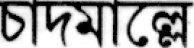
চাদমাল্লে
